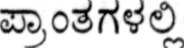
ಪ್ರಾಂತಗಳಲ್ಲಿ
